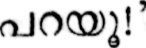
പറയൂ!'
